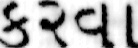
કરવા
